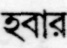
হবার
